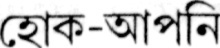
হোক-আপনি
